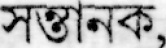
সন্তানক,
